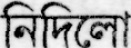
নিদিলো
